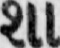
શા
